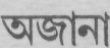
অজানা
